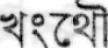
খংথৌ
